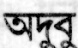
অদুবু
